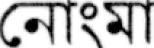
নোংমা
